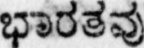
ಭಾರತವು
